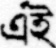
এই
